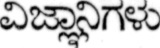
ವಿಜ್ಞಾನಿಗಳು
